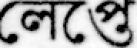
লেপ্তে
